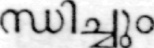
ന്ധിച്ചും
